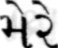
મેરે
